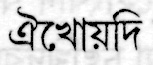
ঐখোয়দি
